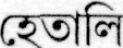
হেতালি
